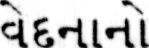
વેદનાનો
